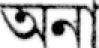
অনা
